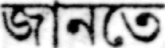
জানতে
